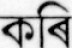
কৰি
